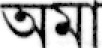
অমা
